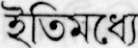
ইতিমধ্যে
